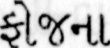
ફોજના
